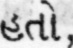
હતો,
